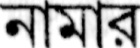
নামার
